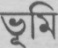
ভূমি
